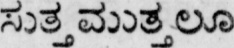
ಸುತ್ತಮುತ್ತಲೂ
